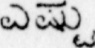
ಎಷ್ಟು
